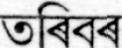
তৰিবৰ
